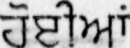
ਹੋਈਆਂ
